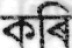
কৰি
